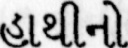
હાથીનો
